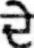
ਦੇ
